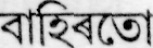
বাহিৰতো
